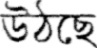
উঠছে
